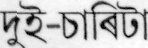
দুই-চাৰিটা
